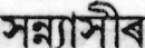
সন্ন্যাসীৰ
